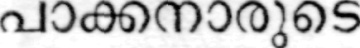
പാക്കനാരുടെ
